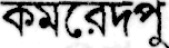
কমরেদপু
